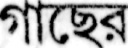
গাছের
